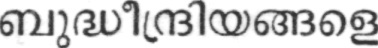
ബുദ്ധീന്ദ്രിയങ്ങളെ
